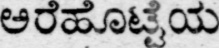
ಅರೆಹೊಟ್ಟೆಯ
